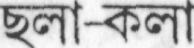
ছলা-কলা
